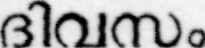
ദിവസം
